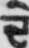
ਦੇ
